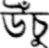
উঁচু
